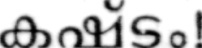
കഷ്ടം!
